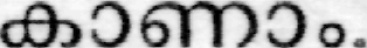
കാണാം.
